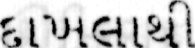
દાખલાથી
